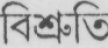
বিশ্রুতি
